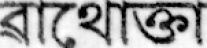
ৱাথোক্তা
